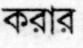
করার
